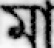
মা
